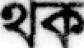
থক
